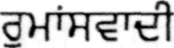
ਰੁਮਾਂਸਵਾਦੀ
